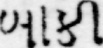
બાકી
